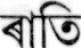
ৰাতি
